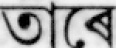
তাৰে
